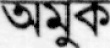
অমুক
